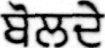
ਬੋਲਦੇ
